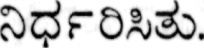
ನಿರ್ಧರಿಸಿತು.
